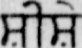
ਸ਼ੀਸ਼ੇ
